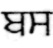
ਬਸ
